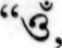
"ওঁ,
